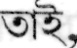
তাই,
